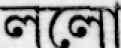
ললো
